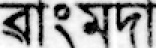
ৱাংমদা
